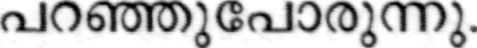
പറഞ്ഞുപോരുന്നു.
